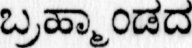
ಬ್ರಹ್ಮಾಂಡದ
